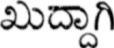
ಖುದ್ದಾಗಿ
